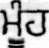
ਮੂੰਹ
